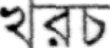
খরচ
